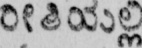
ರೀತಿಯಲ್ಲಿ
